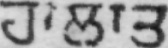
ਹਾਲਾਤ
